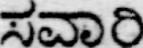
ಸವಾರಿ
